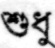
শুধু
